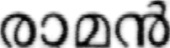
രാമന്‍
